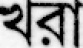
খরা
